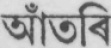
আঁতৰি
